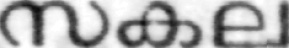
സകല
